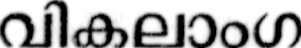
വികലാംഗ
